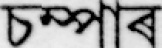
চম্পাৰ
